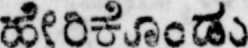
ಹೇರಿಕೊಂಡು
